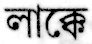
লাক্কে
